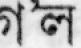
গ'ল
